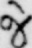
જે
